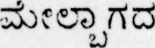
ಮೇಲ್ಬಾಗದ
